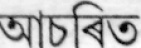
আচৰিত
